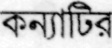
কন্যাটির
